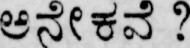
ಅನೇಕವೆ?
